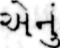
એનું
